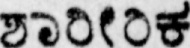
ಶಾರೀರಿಕ
